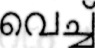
വെച്ച്
